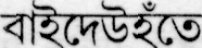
বাইদেউহঁতে
